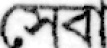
সেবা
